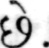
છે.
